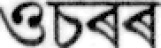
ওচৰৰ
